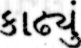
કાઢ્યું
